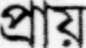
প্রায়
